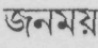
জনময়
